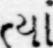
ત્યાં
